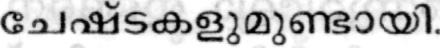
ചേഷ്ടകളുമുണ്ടായി.
